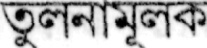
তুলনামূলক
